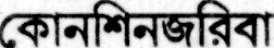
কোনশিনজরিবা
